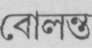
বোলন্ত
